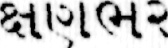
ક્ષણભર
